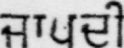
ਜਾਪਦੀ
